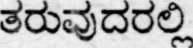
ತರುವುದರಲ್ಲಿ
